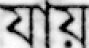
যায়
